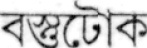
বস্তুটোক
